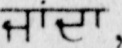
ਜਾਂਦਾ,
